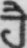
ਹੈ
